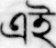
এই
